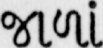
જાળાં
